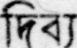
দিব্য
